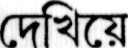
দেখিয়ে
